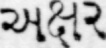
અક્ષર
